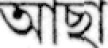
আছা
